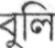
বুলি
